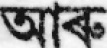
আৰু
